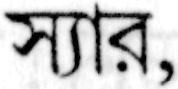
স্যার,
